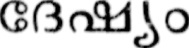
ദേഷ്യം
